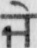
ਜੇ
